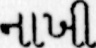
નાખી
